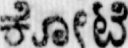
ಕೋಟೆ
